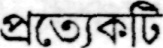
প্রত্যেকটি
